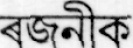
ৰজনীক
